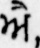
ਐ,
